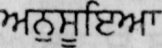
ਅਨੁਸੂਇਆ
